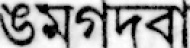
ঙমগদবা
